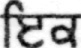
ਇਕ
